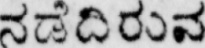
ನಡೆದಿರುವ
